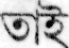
তাই
